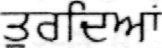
ਤੁਰਦਿਆਂ
